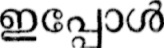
ഇപ്പോള്‍
